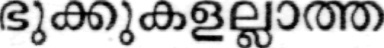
ഭുക്കുകളല്ലാത്ത
